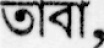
তাবা,
